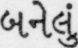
બનેલું
